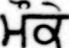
ਮੌਕੇ
